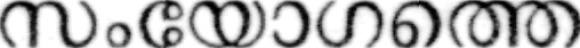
സംയോഗത്തെ
